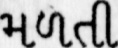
મળતી
